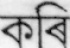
কৰি
